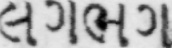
લગભગ
